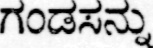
ಗಂಡಸನ್ನು
